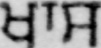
ਖਾਸ
